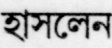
হাসলেন
